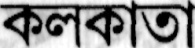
কলকাতা
